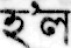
হ'ল
